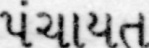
પંચાયત
